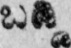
ಬಡ್ಡಿ
